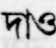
দাও
